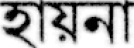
হায়না
